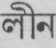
লীন
